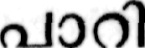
പാറി
